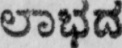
ಲಾಭದ
